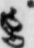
હું
